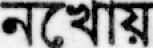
নখোয়
